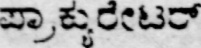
ಪ್ರಾಕ್ಯುಲೇಟರ್
